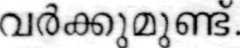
വര്‍ക്കുമുണ്ട്.
